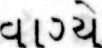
વાગ્યે
